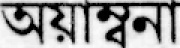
অয়াম্বনা
